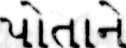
પોતાને
